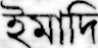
ইমাদি
